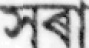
সৰা
